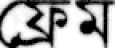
ফ্রেম
